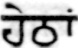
ਹੇਠਾਂ
